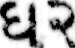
ઘર
